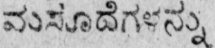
ಮಸೂದೆಗಳನ್ನು
